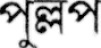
পুল্লপ
